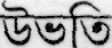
উভতি
